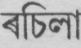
ৰচিলা
